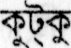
কুট্কু
